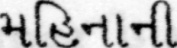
મહિનાની
